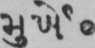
મુર્ખે.
